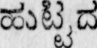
ಹುಟ್ಟಿದ
